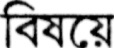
বিষয়ে
